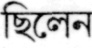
ছিলেন
